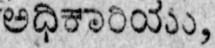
ಅಧಿಕಾರಿಯು,
